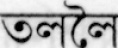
তললৈ
